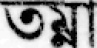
তম্না
